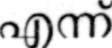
എന്ന്
